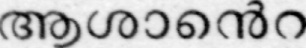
ആശാന്റെ
